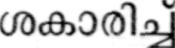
ശകാരിച്ച്
